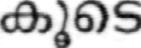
കൂടെ
